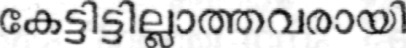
കേട്ടിട്ടില്ലാത്തവരായി
